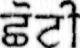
ਛੋਟੀ
